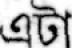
এটা
